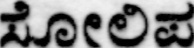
ಸೋಲಿಪ
